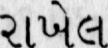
રાખેલ
